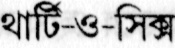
থার্টি-ও-সিক্স
